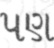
પણ
